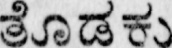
ತೊಡಕು
